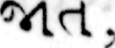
જાત,
